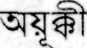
অয়ূক্কী
